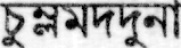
চুম্লমদদুনা
